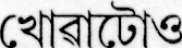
খোৱাটোও
